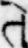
તે
